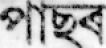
পাছৰ
